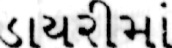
ડાયરીમાં
